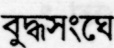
বুদ্ধসংঘে
